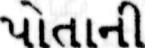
પોતાની
